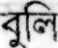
বুলি
